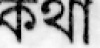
কথা
